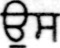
ਉਸ
